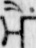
ਮੈਂ
